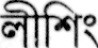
লীশিং
